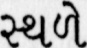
સ્થળે
